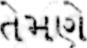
તેમણે
